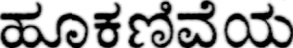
ಹೂಕಣಿವೆಯ
